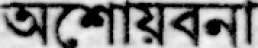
অশোয়বনা
